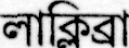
লাক্লিব্রা
